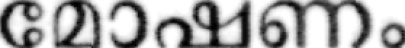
മോഷണം
